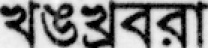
খঙখ্রবরা
